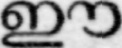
ഈ
